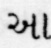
આ
